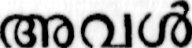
അവള്‍
